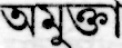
অমুক্তা
